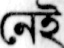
নেই
